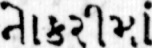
નોકરીમાં
